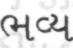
ભવ્ય
